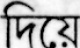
দিয়ে
